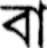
বা
